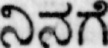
ನಿನಗೆ
